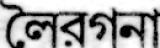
লৈরগনা
